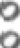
ঃ
